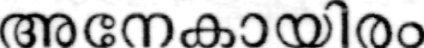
അനേകായിരം
